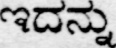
ಇದನ್ನು
